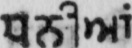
ਧਨੀਆਂ
